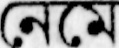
নেমে
